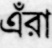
এঁরা
